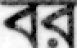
বর
